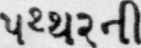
પથ્થરની
